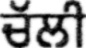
ਚੱਲੀ
